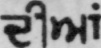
ਦੀਆਂ
